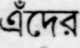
এঁদের
